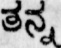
ತನ್ನ
